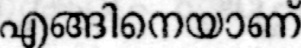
എങ്ങിനെയാണ്
